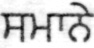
ਸਮਾਨੇ
